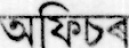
অফিচৰ
